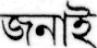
জনাই
